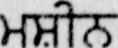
ਮਸ਼ੀਨ
